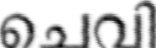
ചെവി
